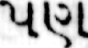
પણ
